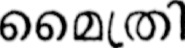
മൈത്രി
